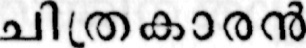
ചിത്രകാരന്‍
